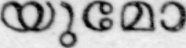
യുമോ
